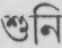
শুনি
